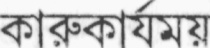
কারুকার্যময়
